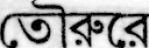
তৌরুরে
